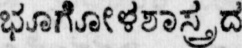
ಭೂಗೋಳಶಾಸ್ತ್ರದ
